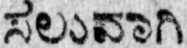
ಸಲುವಾಗಿ
